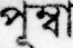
পূম্বা
